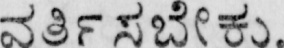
ವರ್ತಿಸಬೇಕು.
